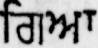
ਗਿਆ
